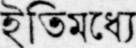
ইতিমধ্যে
